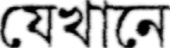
যেখানে
